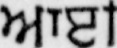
ਆਈ
